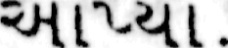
આપ્યા.
